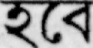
হবে
